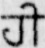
ਹੀ
